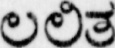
ಲಲಿತ
